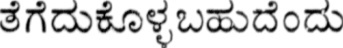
ತೆಗೆದುಕೊಳ್ಳಬಹುದೆಂದು
